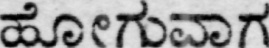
ಹೋಗುವಾಗ
